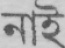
নাই
